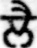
ਲੈ
